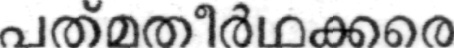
പത്മതീര്‍ഥക്കരെ
